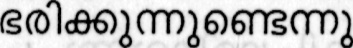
ഭരിക്കുന്നുണ്ടെന്നു
